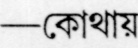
–কোথায়
